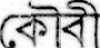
কৌবী
